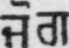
ਜੋਗ
